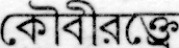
কৌবীরক্ত্রে
